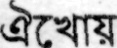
ঐখোয়
